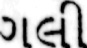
ગલી
